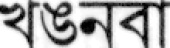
খঙনবা
